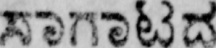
ಸಾಗಾಟದ
